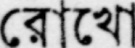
রোখো
